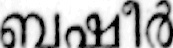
ബഷീര്‍
